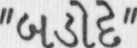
"બડોદે"
